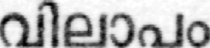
വിലാപം
